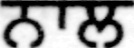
ਨਾਲ
